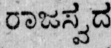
ರಾಜಸ್ವದ
